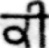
ਕੀ
